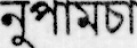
নুপামচা
